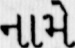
નામે
